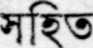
সহিত
